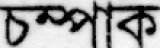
চম্পাক
